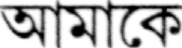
আমাকে
